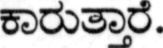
ಕಾರುತ್ತಾರೆ.
